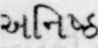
અનિષ્ઠ
